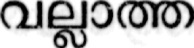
വല്ലാത്ത
